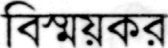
বিস্ময়কর
